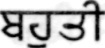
ਬਹੁਤੀ
